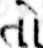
તો
